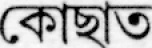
কোছাত
